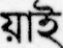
য়াই
